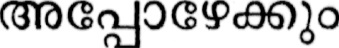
അപ്പോഴേക്കും
